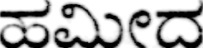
ಹಮೀದ
